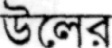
উলের
